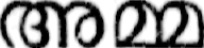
അമ്മ
